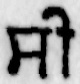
ਸੀ
